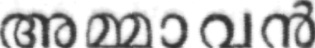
അമ്മാവന്‍
